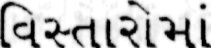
વિસ્તારોમાં
